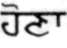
ਹੋਣਾ
